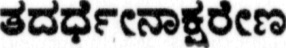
ತದರ್ಧೇನಾಕ್ಷರೇಣ
